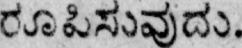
ರೂಪಿಸುವುದು.
